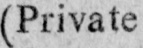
(Private
